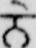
ਨੇ
